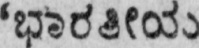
‘ಭಾರತೀಯ
